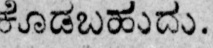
ಕೊಡಬಹುದು.
